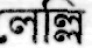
লেল্লি
